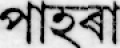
পাহৰা
